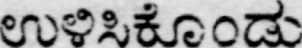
ಉಳಿಸಿಕೊಂಡು
